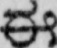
ಈ
